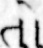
તો
